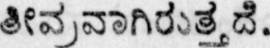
ತೀವ್ರವಾಗಿರುತ್ತದೆ.
